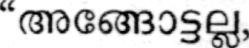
“അങ്ങോട്ടല്ല,
